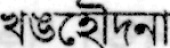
খঙহৌদনা
